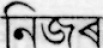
নিজৰ
